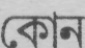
কোন
